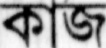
কাজ
